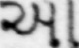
આ
